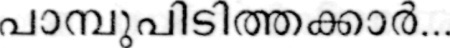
പാമ്പുപിടിത്തക്കാര്‍...
